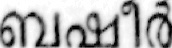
ബഷീര്‍
